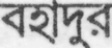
বহাদুর
